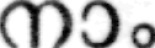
നാം
